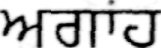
ਅਗਾਂਹ
